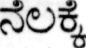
ನೆಲಕ್ಕೆ
